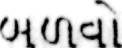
બળવો
